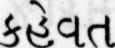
કહેવત
